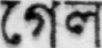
গেল
